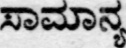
ಸಾಮಾನ್ಯ
